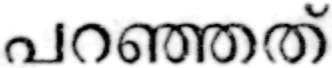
പറഞ്ഞത്
